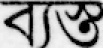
ব্যস্ত
